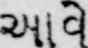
આવે
